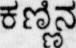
ಕಣ್ಣಿನ
